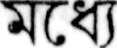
মধ্যে
